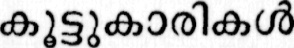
കൂട്ടുകാരികള്‍
